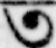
ত
